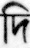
দি
